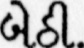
બેઠી.
